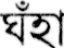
ঘঁহা
